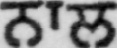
ਨਾਲ
